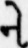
ને
